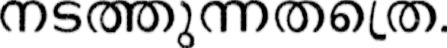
നടത്തുന്നതത്രെ.
